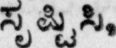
ಸೃಷ್ಟಿಸಿ,
